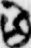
છે
